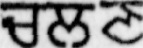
ਚਲਣ
